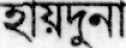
হায়দুনা
